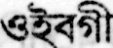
ওইবগী
